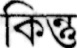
কিন্তু
